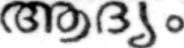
ആദ്യം
